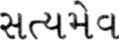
સત્યમેવ
